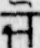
ਜੋ
